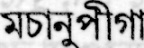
মচানুপীগা
